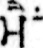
ਮੈਂ
